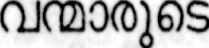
വന്മാരുടെ
